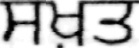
ਸਖ਼ਤ
